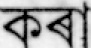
কৰা
